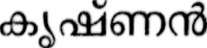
കൃഷ്ണന്‍
